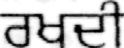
ਰਖਦੀ
